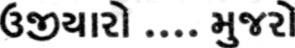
ઉજીયારો......મુજરો
